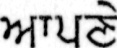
ਆਪਣੇ
